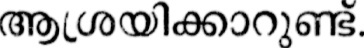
ആശ്രയിക്കാറുണ്ട്.
